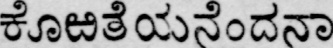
ಕೊಱತೆಯನೆಂದನಾ
